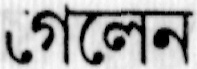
গেলেন
